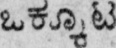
ಒಕ್ಕೂಟ
